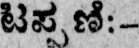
ಟಿಪ್ಪಣಿ:-
